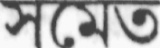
সমেত
